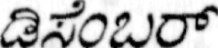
ಡಿಸೆಂಬರ್
